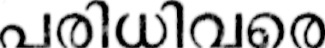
പരിധിവരെ
